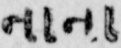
નાના
